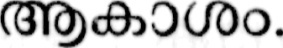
ആകാശം.
